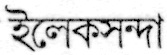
ইলেকসন্দা
